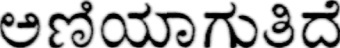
ಅಣಿಯಾಗುತಿದೆ
